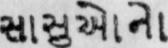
સાસુઓનો
